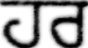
ਹਰ
